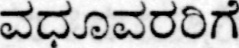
ವಧೂವರರಿಗೆ
